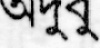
অদুবু
